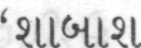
'શાબાશ
